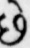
છે
